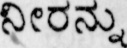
ನೀರನ್ನು
